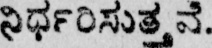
ನಿರ್ಧರಿಸುತ್ತವೆ.
